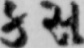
કસ
